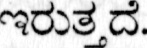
ಇರುತ್ತದೆ.
